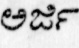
ಅರ್ಜಿ
